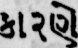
કારણે
